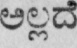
ಅಲ್ಲದೆ
